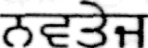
ਨਵਤੇਜ
